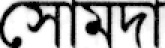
সোমদা
